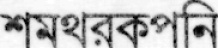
শমথরকপনি
